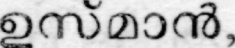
ഉസ്മാന്‍,
